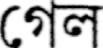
গেল
